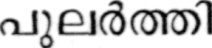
പുലര്‍ത്തി
